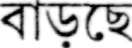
বাড়ছে
